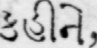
કહીને,
